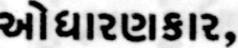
ઓધારણકાર,
